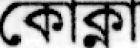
কোক্না
